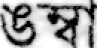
ঙম্বা
